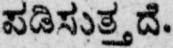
ಪಡಿಸುತ್ತದೆ.
